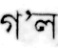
গ'ল
